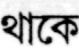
থাকে
